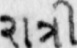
રાત્રી
